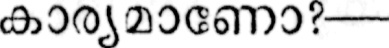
കാര്യമാണോ?-
